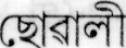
ছোৱালী
